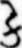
કે
